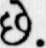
છે.
